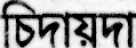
চিদায়দা
